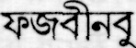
ফজবীনবু
